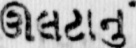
ઊલટાનું
